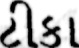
ટીકા
